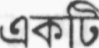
একটি
